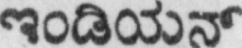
ಇಂಡಿಯನ್
